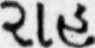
રાહ
